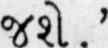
જશે.'
